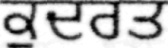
ਕੁਦਰਤ
